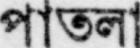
পাতলা
